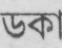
ডকা
